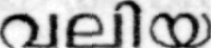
വലിയ
